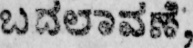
ಬದಲಾವಣೆ,
